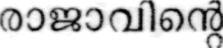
രാജാവിന്റെ
